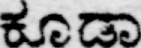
ಕೂಡಾ
